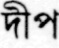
দীপ
